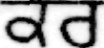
ਕਰ
